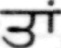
ਤਾਂ
